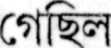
গেছিল
